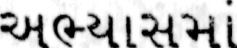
અભ્યાસમાં
